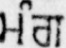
ਮੰਗ
